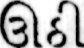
ઊઠી
